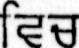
ਵਿਚ
